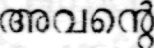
അവന്റെ
